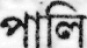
পালি
